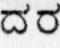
ದರ
